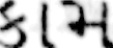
કામ
